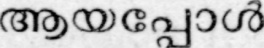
ആയപ്പോള്‍
